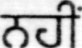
ਨਹੀਂ
